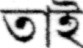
তাই
